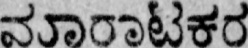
ಮಾರಾಟಕರ
